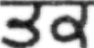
ਤਕ
